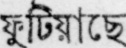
ফুটিয়াছে
